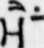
ਮੈਂ
